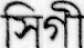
সিগী
